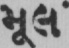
મૂલં
